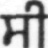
ਸੀ
